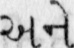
અને
